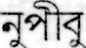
নুপীবু
